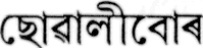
ছোৱালীবোৰ
